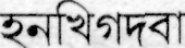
হনখিগদবা
